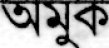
অমুক
